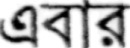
এবার
